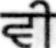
ਵੀ
